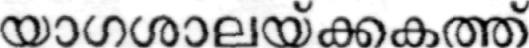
യാഗശാലയ്ക്കകത്ത്
